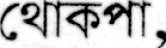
থোকপা,
